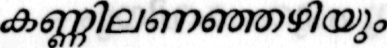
കണ്ണിലണഞ്ഞഴിയും
